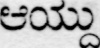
ಆಯ್ದು
